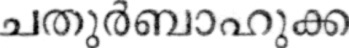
ചതുര്‍ബാഹുക്ക
